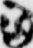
છે
